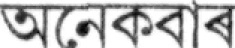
অনেকবাৰ
